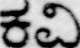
ಕವಿ
